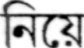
নিয়ে
